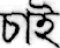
চাই
